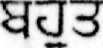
ਬਹੁਤ
